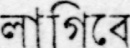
লাগিবে
